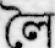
লৈ
